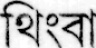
থিংবা
